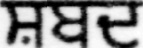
ਸ਼ਬਦ
